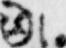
છો.
